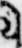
યે
